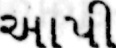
આપી
